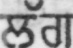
ਲੱਗ
